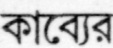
কাব্যের
